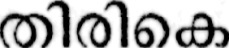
തിരികെ
